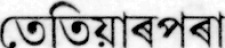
তেতিয়াৰপৰা
